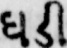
ઘડી
